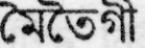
মৈতৈগী
